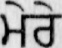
ਮੇਰੇ
